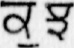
ਕੁਝ
